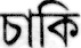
চাকি
